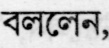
বললেন,
